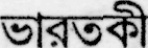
ভারতকী
